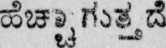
ಹೆಚ್ಚಾಗುತ್ತದೆ
